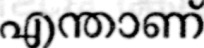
എന്താണ്
